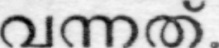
വന്നത്.
